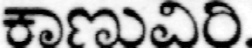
ಕಾಣುವಿರಿ.
